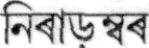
নিৰাড়ম্বৰ
